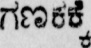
ಗಣಕಕ್ಕೆ
